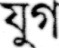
যুগ
